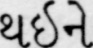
થઈને
